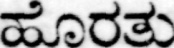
ಹೊರತು
